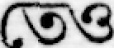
তেও
